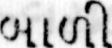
બાળી
